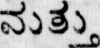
ಮತ್ತು
